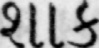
શાક
